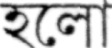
হলো
